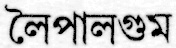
লৈপালগুম
